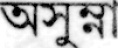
অসুম্না
